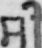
ਸੀ
